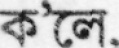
ক'লে,
